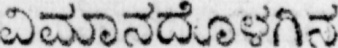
ವಿಮಾನದೊಳಗಿನ
